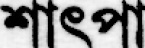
শাৎপা
